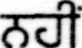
ਨਹੀਂ
